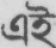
এই
